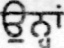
ਉਨ੍ਹਾਂ
